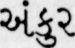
અંકુર
